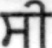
ਸੀ
